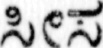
ಸೀಸ
